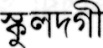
স্কুলদগী
